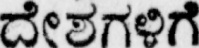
ದೇಶಗಳಿಗೆ
